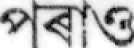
পৰাও
